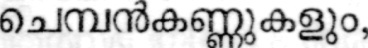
ചെമ്പന്‍കണ്ണുകളും,
